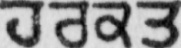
ਹਰਕਤ
